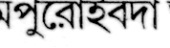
মপুরোইবদা
